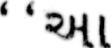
"આ
